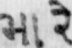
મારે
